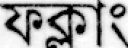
ফক্লাং
